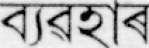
ব্যৱহাৰ
